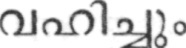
വഹിച്ചും
